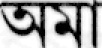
অমা
